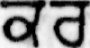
ਕਰ
